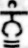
ਨੂੰ
